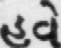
હવે
